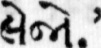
લેજો.'
